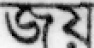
জয়
